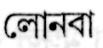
লোনবা
